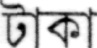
টাকা
